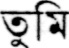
তুমি
